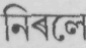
নিৰলে
